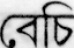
বেচি
